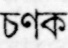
চণক
